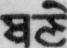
ਬਣੇ
